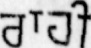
ਰਾਹੀ
